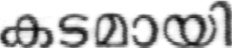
കടമായി
